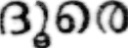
ദൂരെ
